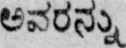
ಅವರನ್ನು
